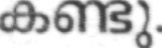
കണ്ടു.
